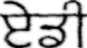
ਏਡੀ
